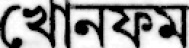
খোনফম
